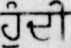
ਹੁੰਦੀ
